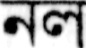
নল
